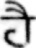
ਹੈ
